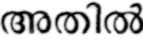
അതില്‍
